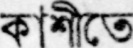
কাশীতে
